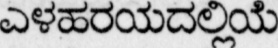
ಎಳಹರಯದಲ್ಲಿಯೆ
